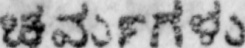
ಚರ್ಮಗಳು
